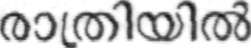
രാത്രിയില്‍
